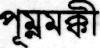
পূম্নমক্কী
